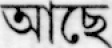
আছে
